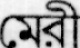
মেরী
